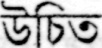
উচিত
